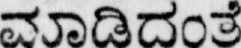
ಮಾಡಿದಂತೆ
